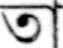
তা
